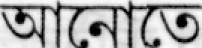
আনোতে
